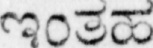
ಇಂತಹ
